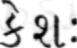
કેશઃ
